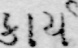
કાર્ય
